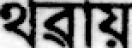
থৱায়
